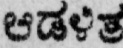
ಆಡಳಿತ
